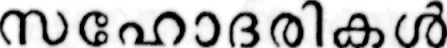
സഹോദരികള്‍
